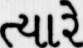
ત્યારે
